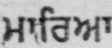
ਮਾਰਿਆ
